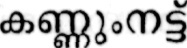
കണ്ണുംനട്ട്
